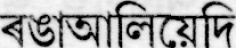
ৰঙাআলিয়েদি
